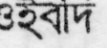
ওইবদি
